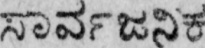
ಸಾರ್ವಜನಿಕ
